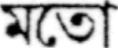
মতো
